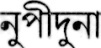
নুপীদুনা
